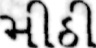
મીઠી
